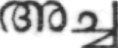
അച്ച
